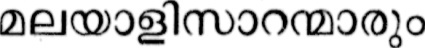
മലയാളിസാറന്മാരും
